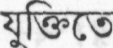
যুক্তিতে
